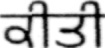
ਕੀਤੀ
